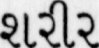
શરીર
